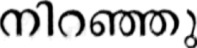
നിറഞ്ഞു
